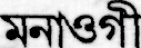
মনাওগী
